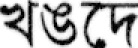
খঙদে
